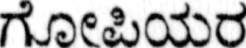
ಗೋಪಿಯರ
